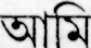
আমি
